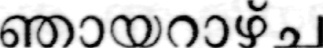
ഞായറാഴ്ച
